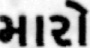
મારો
